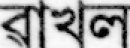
ৱাখল
